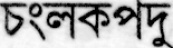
চংলকপদু
